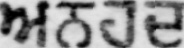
ਅਨਹਦ
